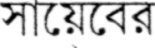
সায়েবের
